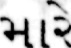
મારે
